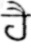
ਹੈ
